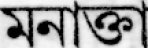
মনাক্তা
